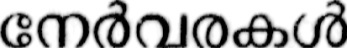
നേര്‍വരകള്‍
